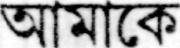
আমাকে
